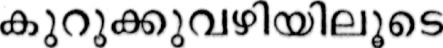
കുറുക്കുവഴിയിലൂടെ
